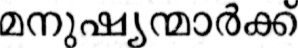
മനുഷ്യന്മാര്‍ക്ക്
